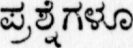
ಪ್ರಶ್ನೆಗಳೂ
